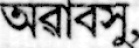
অৱাবসু,
